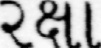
રક્ષા
